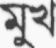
মুখ
